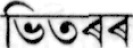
ভিতৰৰ
